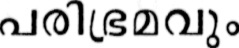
പരിഭ്രമവും
